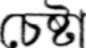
চেষ্টা
